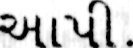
આપી.
